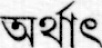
অর্থাৎ
